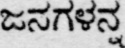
ಜನಗಳನ್ನ
